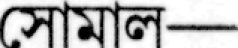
সোমাল-
